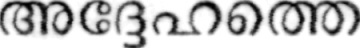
അദ്ദേഹത്തെ
